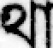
থা
